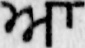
ਆ
